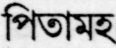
পিতামহ
